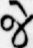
જે
